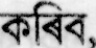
কৰিব,
